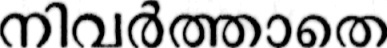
നിവര്‍ത്താതെ
